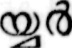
യ്യര്‍
